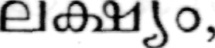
ലക്ഷ്യം,
